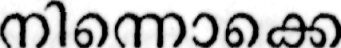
നിന്നൊക്കെ
